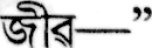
জীৱ-"
